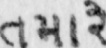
તમારે
